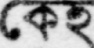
কেহ
